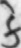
કે
